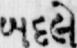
બદલે
